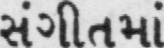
સંગીતમાં
